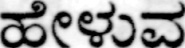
ಹೇಳುವ
